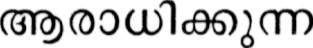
ആരാധിക്കുന്ന
